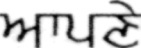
ਆਪਣੇ
